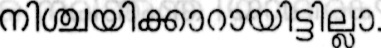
നിശ്ചയിക്കാറായിട്ടില്ലാ.
